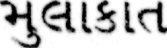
મુલાકાત
